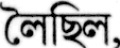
লৈছিল,
